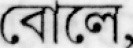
বোলে,
